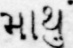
માથું
